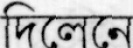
দিলেনে
